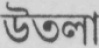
উতলা
